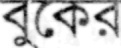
বুকের
